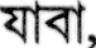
যাবা,
